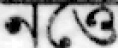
নত্তে
